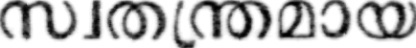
സ്വതന്ത്രമായ
